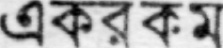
একরকম
